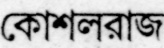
কোশলরাজ
